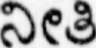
ನೀತಿ
